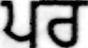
ਪਰ
